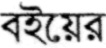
বইয়ের
